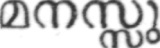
മനസ്സു
